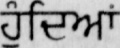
ਹੁੰਦਿਆਂ
